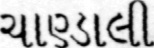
ચાણ્ડાલી
